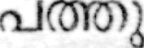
പത്തു
